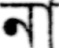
না
